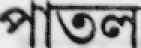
পাতল
